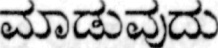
ಮಾಡುವುದು
